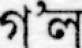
গ'ল
